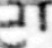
ਦਾ
